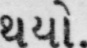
થયો.
